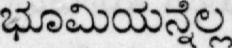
ಭೂಮಿಯನ್ನೆಲ್ಲ
